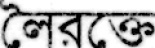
লৈরক্তে
